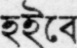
হইবে
